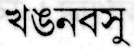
খঙনবসু
